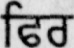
ਫਿਰ
